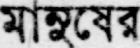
মানুষের
